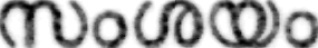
സംശയം
